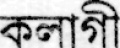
কলাগী
